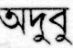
অদুবু
